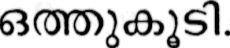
ഒത്തുകൂടി.
